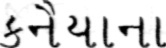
કનૈયાના
